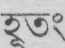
হূতং
